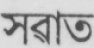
সৱাত
